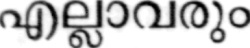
എല്ലാവരും
